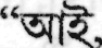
"আই,
